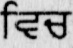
ਵਿਚ
